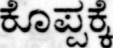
ಕೊಪ್ಪಕ್ಕೆ
